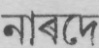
নাৰদে
